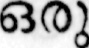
ഒരു
